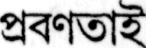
প্রবণতাই
